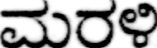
ಮರಳಿ
